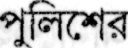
পুলিশের
